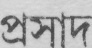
প্ৰসাদ
